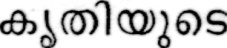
കൃതിയുടെ
